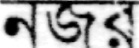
নজর
